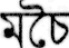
মচৈ
